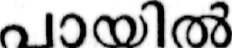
പായില്‍
